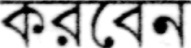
করবেন
